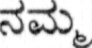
ನಮ್ಮ
